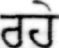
ਰਹੇ
